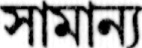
সামান্য
